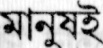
মানুষই
